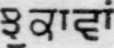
ਝੁਕਾਵਾਂ
